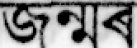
জন্মৰ
